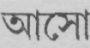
আসো
